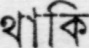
থাকি
